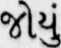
જોયું
